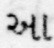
આ
